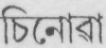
চিনোৱা
